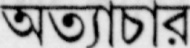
অত্যাচার
